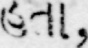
હતા,
